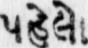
પહેલો
